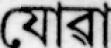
যোৱা
